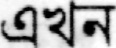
এখন
